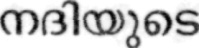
നദിയുടെ
